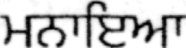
ਮਨਾਇਆ
